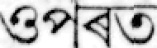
ওপৰত
